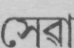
সেৱা
